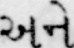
અને
